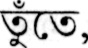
তুঁতে,
